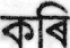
কৰি
